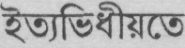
ইত্যভিধীয়তে
